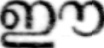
ഈ
